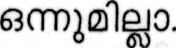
ഒന്നുമില്ലാ.
